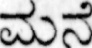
ಮನೆ
